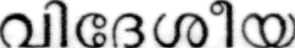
വിദേശീയ
